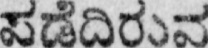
ಪಡೆದಿರುವ
